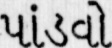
પાંડવો
